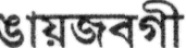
ঙায়জবগী
